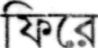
ফিরে
